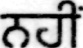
ਨਹੀਂ
